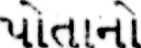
પોતાનો
